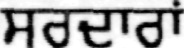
ਸਰਦਾਰਾਂ
